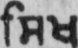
ਸਿਖ
